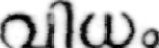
വിധം
